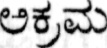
ಅಕ್ರಮ
